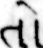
તો
